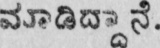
ಮಾಡಿದ್ದಾನೆ.
